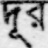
দূর
